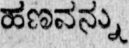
ಹಣವನ್ನು
